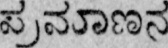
ಪ್ರಮಾಣನ
